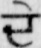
ਦੇ
